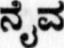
ನೈವ
